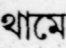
থামে
